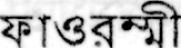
ফাওরম্মী
